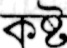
কষ্ট
